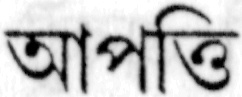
আপত্তি
